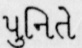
પુનિતે
